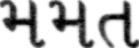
મમત
